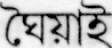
ঘৈয়াই
